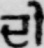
ਦੀ
